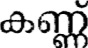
കണ്ണ്
